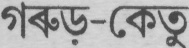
গৰুড়-কেতু
